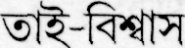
তাই-বিশ্বাস
